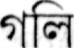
গলি
